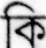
কি
